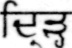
ਦ੍ਰਿੜ੍ਹ
